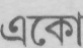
একো
